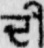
ਦੀ
